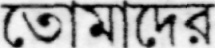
তোমাদের
